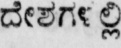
ದೇಶಗಳಲ್ಲಿ
